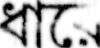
ধারে
